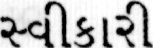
સ્વીકારી
